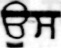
ਉਸ
